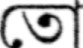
তো
